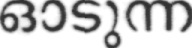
ഓടുന്ന
